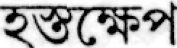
হস্তক্ষেপ
